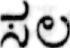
ಸಲ
